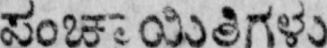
ಪಂಚಾಯಿತಿಗಳು
